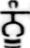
ਨੂੰ
